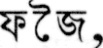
ফজৈ,
